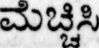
ಮೆಚ್ಚಿಸಿ
